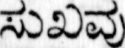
ಸುಖವು
